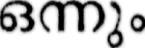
ഒന്നും
